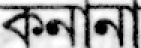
কনানা
